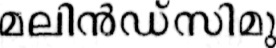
മലിന്‍ഡ്സിമു
